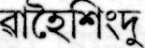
ৱাহৈশিংদু
